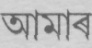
আমাৰ
